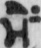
ਮੈਂ
